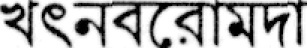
খৎনবরোমদা
